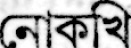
নোকখি
